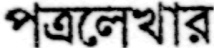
পত্রলেখার
